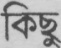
কিছু
